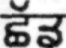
ਛੱਡ
